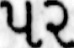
પર
